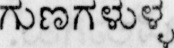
ಗುಣಗಳುಳ್ಳ
